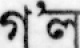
গ'ল
